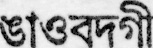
ঙাওবদগী
